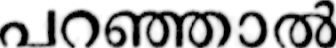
പറഞ്ഞാല്‍
